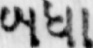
બધા
